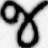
જ
